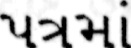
પત્રમાં
